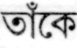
তাঁকে
